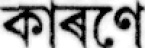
কাৰণে
